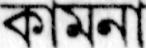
কামনা
